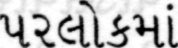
પરલોકમાં
